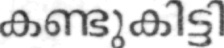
കണ്ടുകിട്ടി
